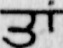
ਤਾਂ
